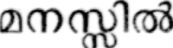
മനസ്സില്‍
